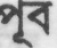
পূব
